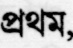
প্রথম,
